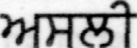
ਅਸਲੀ
